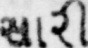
સારી
